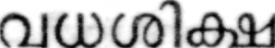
വധശിക്ഷ
